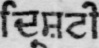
ਦ੍ਰਿਸ਼ਟੀ
